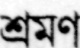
শ্রমণ
